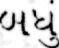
બધું
